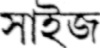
সাইজ
